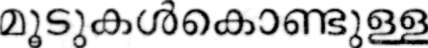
മൂടുകള്‍കൊണ്ടുള്ള
